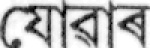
যোৱাৰ
